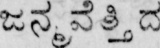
ಜನ್ಮವೆತ್ತಿದ
